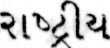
રાષ્ટ્રીય
